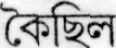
কৈছিল
